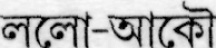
ললো-আকৌ
